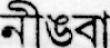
নীঙবা
